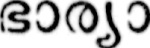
ഭാര്യാ
